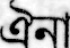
ঐনা
